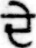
ਦੇ
